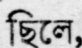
ছিলে,
